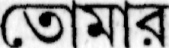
তোমার
